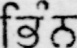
ਭਿੰਨ
